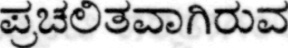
ಪ್ರಚಲಿತವಾಗಿರುವ
